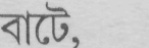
বাটে,
